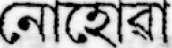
নোহোৱা
